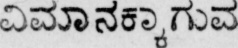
ವಿಮಾನಕ್ಕಾಗುವ
